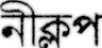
নীক্লপ
